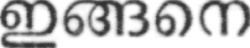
ഇങ്ങനെ
